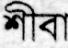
শীবা
